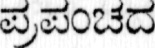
ಪ್ರಪಂಚದ
